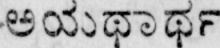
ಅಯಥಾರ್ಥ
